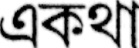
একথা
